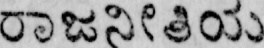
ರಾಜನೀತಿಯ
